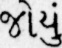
જોયું
